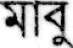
মাবু
